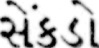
સેંકડો
